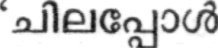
‘ചിലപ്പോള്‍
